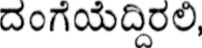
ದಂಗೆಯೆದ್ದಿರಲಿ,
